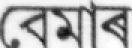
বেমাৰ
